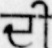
ਦੀ
